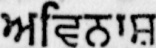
ਅਵਿਨਾਸ਼
